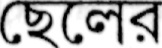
ছেলের
